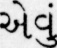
એવું
